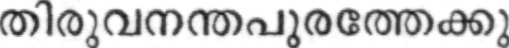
തിരുവനന്തപുരത്തേക്കു
